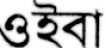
ওইবা
